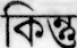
কিন্তু
